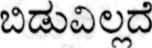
ಬಿಡುವಿಲ್ಲದೆ
